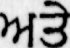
ਅਤੇ
